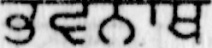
ਭਵਨਾਥ
